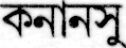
কনানসু
